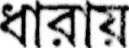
ধারায়
